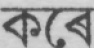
কৰে
